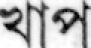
খাপ
